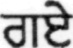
ਗਏ
